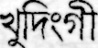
খুদিংগী
